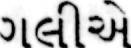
ગલીએ
